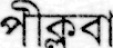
পীক্লবা
